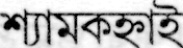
শ্যামকহ্ণাই
